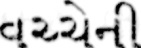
વચ્ચેની
